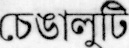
চেঙালুটি
